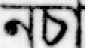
নচা
